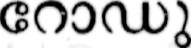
റോഡു
